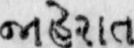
જાહેરાત
